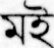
মই
